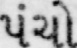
પંચો
